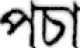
পচা
